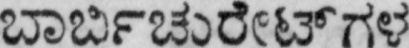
ಬಾರ್ಬಿಚುರೇಟ್‌ಗಳ
